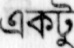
একটু
